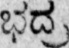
ಭದ್ರ
